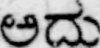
ಅದು
